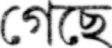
গেছে
